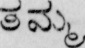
ತಮ್ಮ
